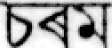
চৰম
